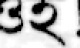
ওহ
